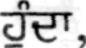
ਹੁੰਦਾ,
